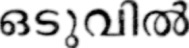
ഒടുവില്‍
